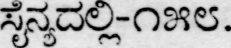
ಸೈನ್ಯದಲ್ಲಿ-೧೫೮.
